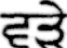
ਵੜੇ
